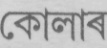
কোলাৰ
